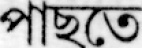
পাছতে
